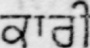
ਕਾਰੀ
